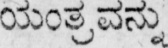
ಯಂತ್ರವನ್ನು
